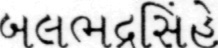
બલભદ્રસિંહે
